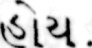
હોય.
